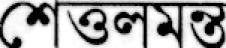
শেত্তলমন্ত
